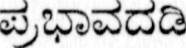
ಪ್ರಭಾವದಡಿ
